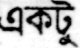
একটু
